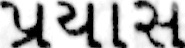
પ્રયાસ
